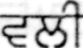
ਵਲੀ
